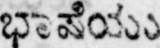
ಭಾಷೆಯು
